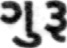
ગુરૂ
